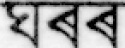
ঘৰৰ
